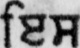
ਇਸ
